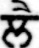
ਲੈ
